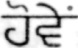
ਹੋਵੇਂ
